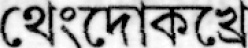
থেংদোকখ্রে
